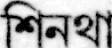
শিনথা
